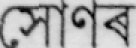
সোণৰ
